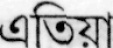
এতিয়া
